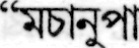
“মচানুপা
